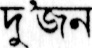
দু'জন
